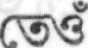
তেওঁ
